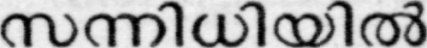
സന്നിധിയില്‍
